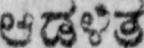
ಆಡಳಿತ
